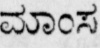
ಮಾಂಸ
